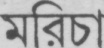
মরিচা
